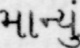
માન્યું
